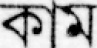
কাম
